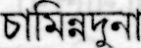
চামিন্নদুনা
